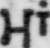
ਮਾਂ
